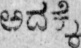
ಅದಕ್ಕೆ
